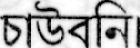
চাউবনি।
